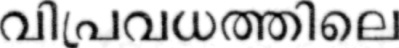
വിപ്രവധത്തിലെ
